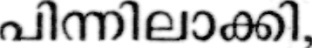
പിന്നിലാക്കി,
